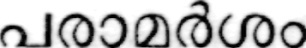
പരാമര്‍ശം
